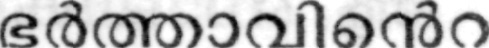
ഭര്‍ത്താവിന്റെ
